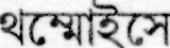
থম্মোইসে
